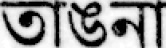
তাঙনা
